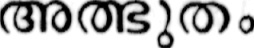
അത്ഭുതം
